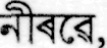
নীৰৱে,
